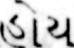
હોય
